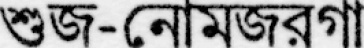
শুজ-নোমজরগা
